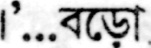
৷’...বড়ো
